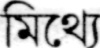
মিথ্যে
